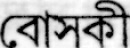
বোসকী
